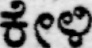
ಕೇಳಿ
